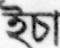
ইচা
